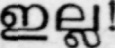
ഇല്ല!
